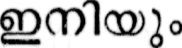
ഇനിയും
